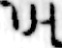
ખ
